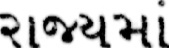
રાજ્યમાં
